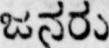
ಜನರು
